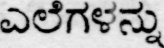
ಎಲೆಗಳನ್ನು
